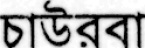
চাউরবা
